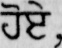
ਹੋਏ,
